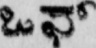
ಒನ್
